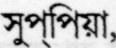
সুপ্পিয়া,
